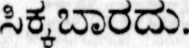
ಸಿಕ್ಕಬಾರದು.
